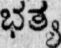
ಭತ್ಯ
